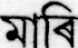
মাৰি
